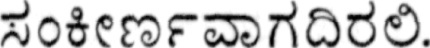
ಸಂಕೀರ್ಣವಾಗದಿರಲಿ.
